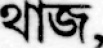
থাজ,
